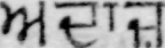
ਅਦਾਜ਼
